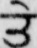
ਤੇ
